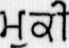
ਮੁਕੀ
